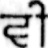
ਵੀ
